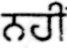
ਨਹੀਂ
